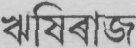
ঋষিৰাজ
